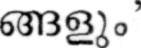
ങ്ങളും'
